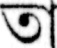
তা
